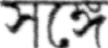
সঙ্গে
